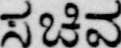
ಸಚಿವ
